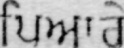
ਪਿਆਰੇ
